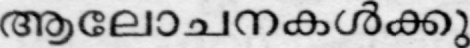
ആലോചനകള്‍ക്കു
